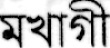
মখাগী
